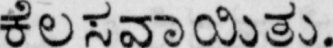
ಕೆಲಸವಾಯಿತು.
